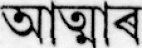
আত্মাৰ
